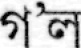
গ'ল
